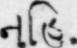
નહિ.
